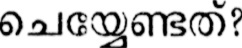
ചെയ്യേണ്ടത്?
